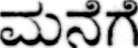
ಮನೆಗೆ
